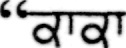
''ਕਾਕਾ
